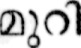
മുറി
